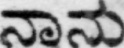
ನಾನು
